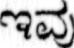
ಇವು
